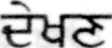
ਦੇਖਣ
